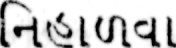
નિહાળવા
